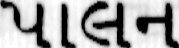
પાલન
